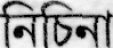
নিচিনা
